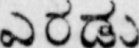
ಎರಡು
